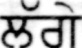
ਲੱਗੇ
